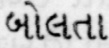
બોલતા
